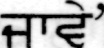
ਜਾਵੇ'
